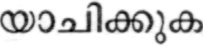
യാചിക്കുക
